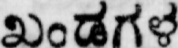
ಖಂಡಗಳ
